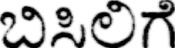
ಬಿಸಿಲಿಗೆ
